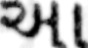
આ
